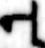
ન
